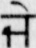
ਜੇ
